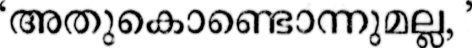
‘അതുകൊണ്ടൊന്നുമല്ല,’
